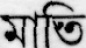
মাতি
